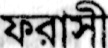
ফরাসী
